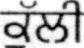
ਕੁੱਲੀ
